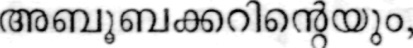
അബൂബക്കറിന്റെയും,
